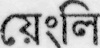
য়েংলি
